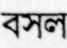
বসল
